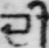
ਦੀ
